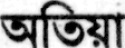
অতিয়া
